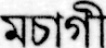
মচাগী
